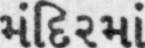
મંદિરમાં
